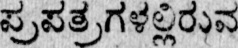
ಪ್ರಪತ್ರಗಳಲ್ಲಿರುವ
